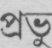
প্ৰভু
